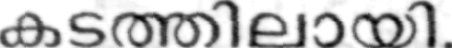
കടത്തിലായി.
